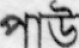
পাউ
